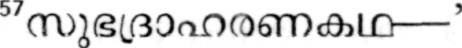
57സുഭദ്രാഹരണകഥ-'
